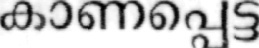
കാണപ്പെട്ട
